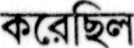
করেছিল
